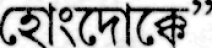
হোংদোক্কে”
